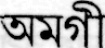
অমগী
